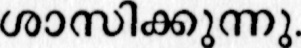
ശാസിക്കുന്നു.
